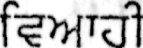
ਵਿਆਹੀ
